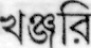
খঞ্জরি
